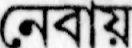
নেবায়
